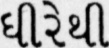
ધીરેથી
